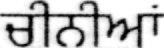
ਚੀਨੀਆਂ
